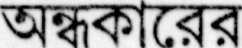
অন্ধকারের
